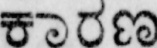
ಕಾರಣ
